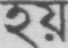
হয়
